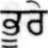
ਭੂਰੇ
